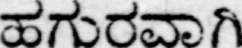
ಹಗುರವಾಗಿ
